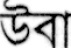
উবা
